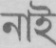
নাই
